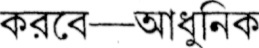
করবে–আধুনিক
